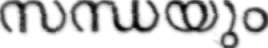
സന്ധയും
